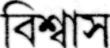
বিশ্বাস
